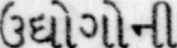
ઉધોગોની
